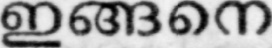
ഇങ്ങനെ
